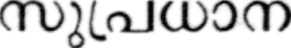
സുപ്രധാന
